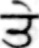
ਤੇ
